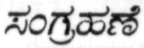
ಸಂಗ್ರಹಣೆ
